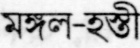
মঙ্গল-হস্তী
